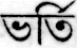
ভর্তি
